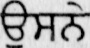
ਉਸਨੇ
